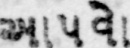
આપવો
